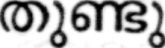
തുണ്ടു
